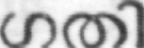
ഗതി
